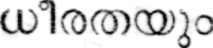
ധീരതയും
